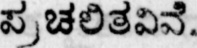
ಪ್ರಚಲಿತವಿವೆ.
